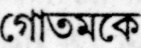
গোতমকে
